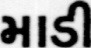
માડી
